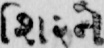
શિરને
